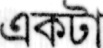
একটা
